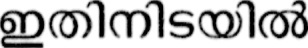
ഇതിനിടയില്‍
